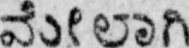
ಮೇಲಾಗಿ
